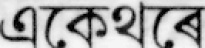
একেথৰে
